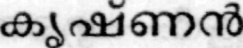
കൃഷ്ണന്‍
